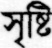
সৃষ্টি
